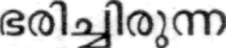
ഭരിച്ചിരുന്ന
